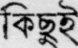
কিছুই
